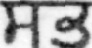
ਸਭ
